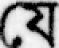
যে
